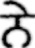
ਨੇ
